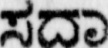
ಸದಾ
